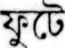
ফুটে
